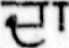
ਦਾ
